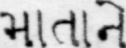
માતાને
